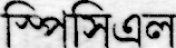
স্পিসিএল
